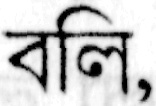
বলি,
